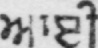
ਆਈ
